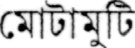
মোটামুটি
